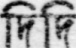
দিদি
